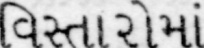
વિસ્તારોમાં
